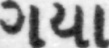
ગયા
